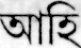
আহি
